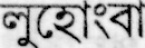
লুহোংবা
